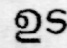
ഉട
